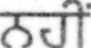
ਨਹੀਂ
